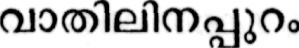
വാതിലിനപ്പുറം
